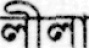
লীলা
